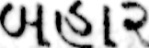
બહાર
